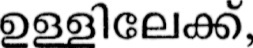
ഉള്ളിലേക്ക്,
